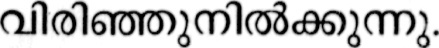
വിരിഞ്ഞുനില്‍ക്കുന്നു.
